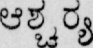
ಆಶ್ಚರ್ಯ
